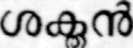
ശക്തന്‍
